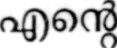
എന്റെ
